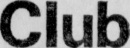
Club
